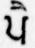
ਪੈ
